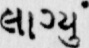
લાગ્યું
